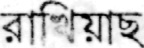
রাখিয়াছ
